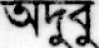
অদুবু
